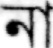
না
